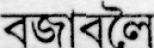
বজাবলৈ
